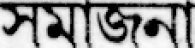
সমাজনা
